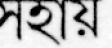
সহায়
